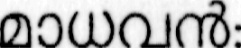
മാധവന്‍:
